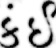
કંઇ
